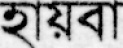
হায়বা
